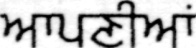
ਆਪਣੀਆਂ
